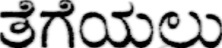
ತೆಗೆಯಲು
